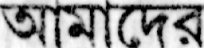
আমাদের
